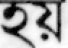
হয়
